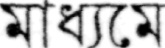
মাধ্যমে
